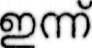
ഇന്ന്
